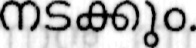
നടക്കും.
